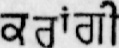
ਕਰਾਂਗੀ
